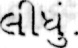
લીધું.
